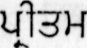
ਪ੍ਰੀਤਮ
